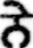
ਨੇ
